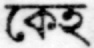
কেহ
